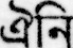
ঐনি
